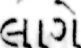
લાગે
